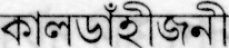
কালডাঁহীজনী
